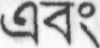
এবং
